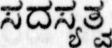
ಸದಸ್ಯತ್ವ
